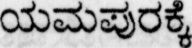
ಯಮಪುರಕ್ಕೆ
